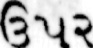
ઉપર
